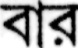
বার
